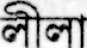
লীলা
